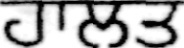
ਹਾਲਤ
